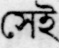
সেই
